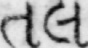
તલ
